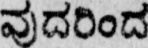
ವುದರಿಂದ
